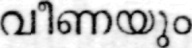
വീണയും
